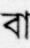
বা
